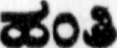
ಹಂತಿ
